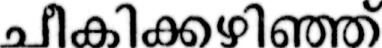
ചീകിക്കഴിഞ്ഞ്
